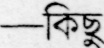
–কিছু
